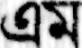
এম
